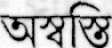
অস্বস্তি
